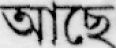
আছে
